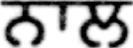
ਨਾਲ
